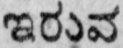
ಇರುವ
